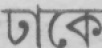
ঢাকে
